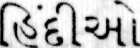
હિંદીઓ
